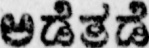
ಅಡೆತಡೆ
